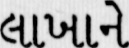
લાખાને
